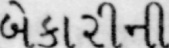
બેકારીની
